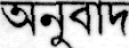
অনুবাদ
